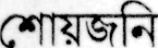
শোয়জনি
